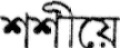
শশীয়ে
